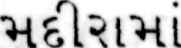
મદીરામાં
